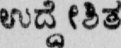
ಉದ್ದೇಶಿತ
